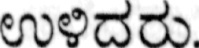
ಉಳಿದರು.
